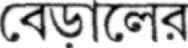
বেড়ালের
